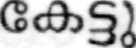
കേട്ടു
